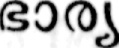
ഭാര്യ
